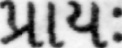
પ્રાય:
